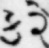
કરે
